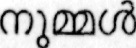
നുമ്മള്‍
